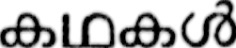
കഥകള്‍
